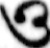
ও
